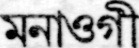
মনাওগী
